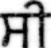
ਸੀ
